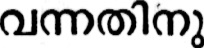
വന്നതിനു
